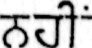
ਨਹੀਂ
